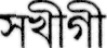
সখীগী
